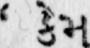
'કેમ
